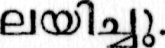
ലയിച്ചു.
